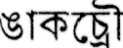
ঙাকচ্রৌ
